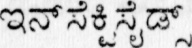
ಇನ್‌ಸೆಕ್ಟಿಸೈಡ್ಸ್
